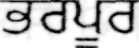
ਭਰਪੂਰ
